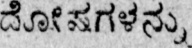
ದೋಷಗಳನ್ನು
